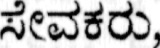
ಸೇವಕರು,
